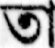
তা
